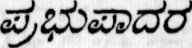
ಪ್ರಭುಪಾದರ
